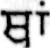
ਥਾਂ
